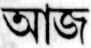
আজ
